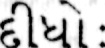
દીધોઃ
